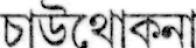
চাউথোকনা
